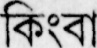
কিংবা
